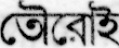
তৌরোই
